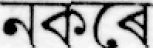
নকৰে
